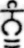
ਨੂੰ
